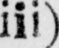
iii)
